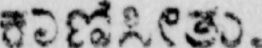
ಕಾಣಿಸೀತು.
